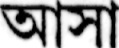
আসা
